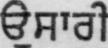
ਉਸਾਰੀ
